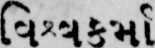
વિશ્વકર્મા
